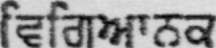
ਵਿਗਿਆਨਕ
